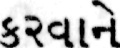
કરવાને
